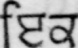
ਇਕ
